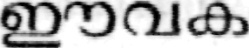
ഈവക
